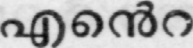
എന്റെ
